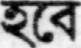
হবে
